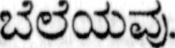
ಬೆಲೆಯವು.
